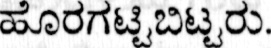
ಹೊರಗಟ್ಟಿಬಿಟ್ಟರು.
